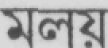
মলয়
